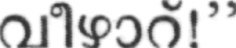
വീഴാറ്!"
